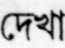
দেখা
